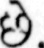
છે.
